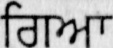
ਗਿਆ
